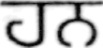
ਹਨ
